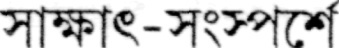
সাক্ষাত্-সংস্পর্শে
